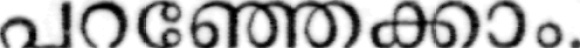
പറഞ്ഞേക്കാം.
